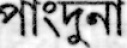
পাংদুনা
